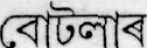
বোটলাৰ
